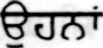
ਉਹਨਾਂ
